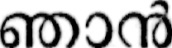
ഞാന്‍
